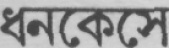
ধনকেসে
